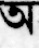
অ
